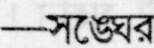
–সঙ্ঘের
